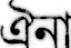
ঐনা
